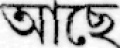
আছে
